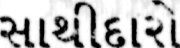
સાથીદારો
